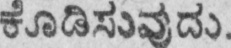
ಕೊಡಿಸುವುದು.
